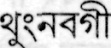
থুংনবগী
